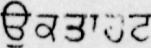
ਉਕਤਾਹਟ
